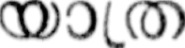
യാത്ര
